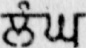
ਲੰਘ
